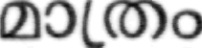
മാത്രം
